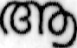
ആ
